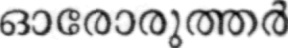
ഓരോരുത്തര്‍
